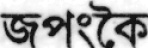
জপংকৈ
